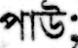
পাউ;
